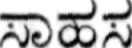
ಸಾಹಸ
